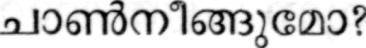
ചാണ്‍നീങ്ങുമോ?
